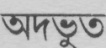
অদভুত
